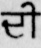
ਦੀ
